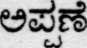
ಅಪ್ಪಣೆ
